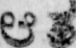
ಆತ
